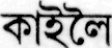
কাইলৈ
